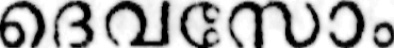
ദെവസോം
